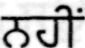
ਨਹੀਂ
